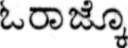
ಓರಾಜ್ಕೊ
